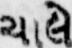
ચાલે
